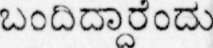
ಬಂದಿದ್ದಾರೆಂದು
